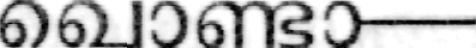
ഖൊണ്ടാ-
